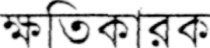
ক্ষতিকারক
